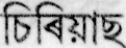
চিৰিয়াছ
